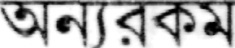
অন্যরকম
